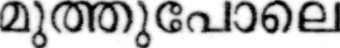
മുത്തുപോലെ
